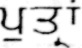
ਪੁਤ੍ਰਾਂ
